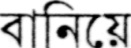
বানিয়ে
